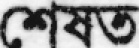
শেষত
